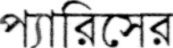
প্যারিসের
